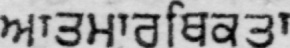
ਆਤਮਾਰਥਿਕਤਾ
